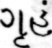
ગૃહં
